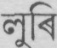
লুৰি
